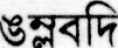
ঙম্লবদি
